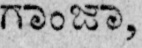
ಗಾಂಜಾ,
